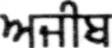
ਅਜੀਬ
